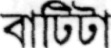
বাটিটা
